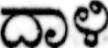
ದಾಳಿ
